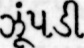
ઝૂંપડી
